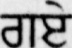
ਗਏ
